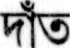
দাঁত
